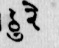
કાઠુરે
